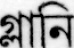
গ্লানি
